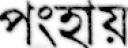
পংহায়
